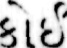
કોઈ
